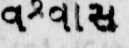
વિશ્વાસ
